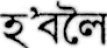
হ'বলৈ
